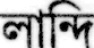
লান্দি
